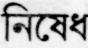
নিষেধ
